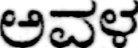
ಅವಳ
